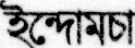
ইন্দোমচা
